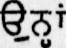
ਉਨ੍ਹਾਂ
